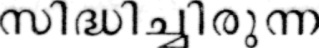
സിദ്ധിച്ചിരുന്ന
